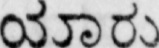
ಯಾರು
